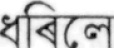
ধৰিলে
